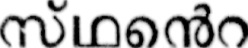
സ്ഥന്റെ
